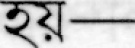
হয়-
